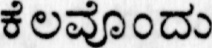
ಕೆಲವೊಂದು
